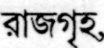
রাজগৃহ,
